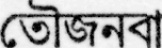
তৌজনবা
